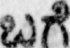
ಬಗೆ
